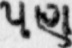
પણ
